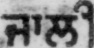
ਜਾਲੀ
